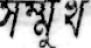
সম্মুখ
